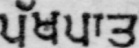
ਪੱਖਪਾਤ
